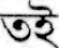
তই
